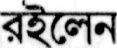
রইলেন
